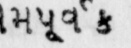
પ્રેમપૂર્વક
